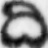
ದಿ
